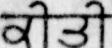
ਕੀਤੀ
